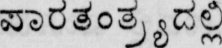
ಪಾರತಂತ್ರ್ಯದಲ್ಲಿ
